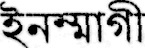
ইনম্মাগী
